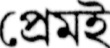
প্রেমই
